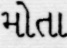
મોતા
